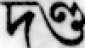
দণ্ড
